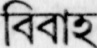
বিবাহ
